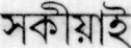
সকীয়াই
